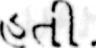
હતી.
